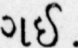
ગઈ.
